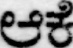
ಆಕೆ
